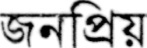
জনপ্রিয়
